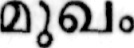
മുഖം
